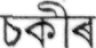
চকীৰ
